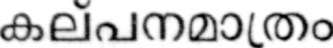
കല്പനമാത്രം
